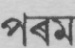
পৰম
